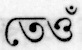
তেওঁ
